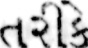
તરીકે
